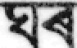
ঘৰ
